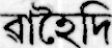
ৱাহৈদি
